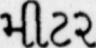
મીટર
